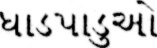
ધાડપાડુઓ
